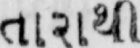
તારાથી
